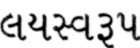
લયસ્વરૂપ
